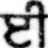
ਈ
